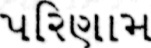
પરિણામ
